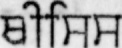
ਥੀਸਿਸ
